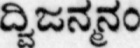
ದ್ವಿಜನ್ಮನಂ
